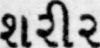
શરીર
